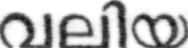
വലിയ
